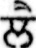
ਲੈ
